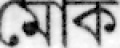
মোক
